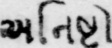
અનિષ્ટો
